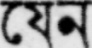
যেন
